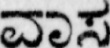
ವಾಸ
